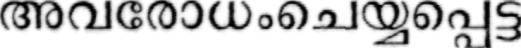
അവരോധംചെയ്യപ്പെട്ട
